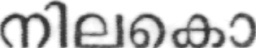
നിലകൊ
